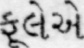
ફૂલેએ
